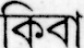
কিবা
